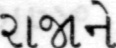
રાજાને
